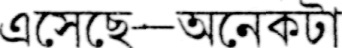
এসেছে–অনেকটা
